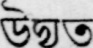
উদ্যত
